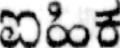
ಐಹಿಕ
